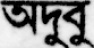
অদুবু
